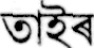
তাইৰ
